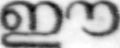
ഈ
